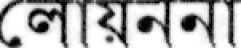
লোয়ননা
